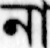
না
